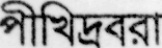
পীখিদ্রবরা
